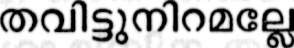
തവിട്ടുനിറമല്ലേ
